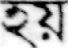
হয়
